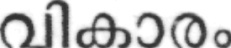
വികാരം
